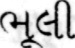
ભૂલી
